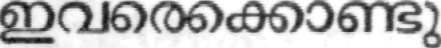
ഇവരെക്കൊണ്ടു
